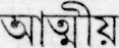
আত্মীয়
